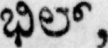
ಭಿಲ್,
